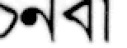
চনবা
